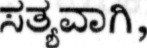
ಸತ್ಯವಾಗಿ,
